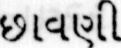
છાવણી
